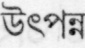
উত্পন্ন
